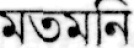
মতমনি
